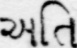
અતિ
